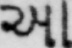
આ
